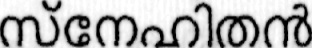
സ്നേഹിതന്‍
